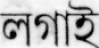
লগাই
